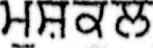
ਮੁਸ਼ਕਲ
